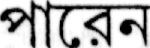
পারেন
